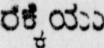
ರೆಕ್ಕೆಯು
